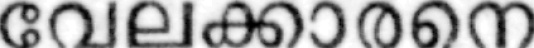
വേലക്കാരനെ
